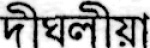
দীঘলীয়া
